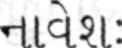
નાવેશઃ
